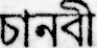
চানবী
